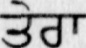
ਤੇਰਾ
